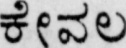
ಕೇವಲ
